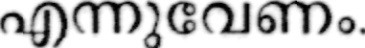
എന്നുവേണം.
